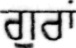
ਗੁਰਾਂ
